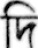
দি
